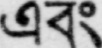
এবং
